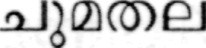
ചുമതല
